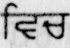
ਵਿਚ
